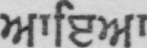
ਆਇਆ
